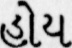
હોય
